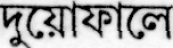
দুয়োফালে
